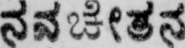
ನವಚೇತನ
